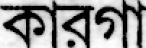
কারগা
